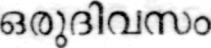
ഒരുദിവസം
